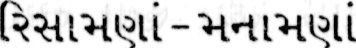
રિસામણાં-મનામણાં
